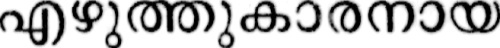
എഴുത്തുകാരനായ
